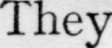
They
